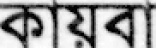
কায়বা
